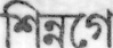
শিন্নগে
